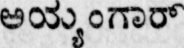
ಅಯ್ಯಂಗಾರ್
